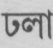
ঢলা
